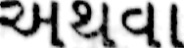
અથવા
